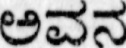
ಅವನ
